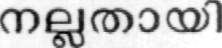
നല്ലതായി
